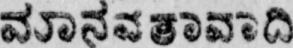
ಮಾನವತಾವಾದಿ
